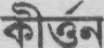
কীৰ্ত্তন
